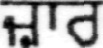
ਜ਼ਾਰ
